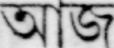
আজ
